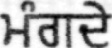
ਮੰਗਦੇ
